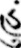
હું
